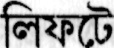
লিফটে
